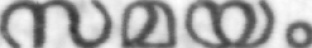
സമയം
